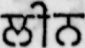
ਲੀਨ
